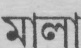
মালা
